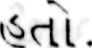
હતો.
